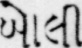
બોલી
